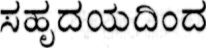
ಸಹೃದಯದಿಂದ
